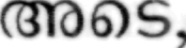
അടെ,
